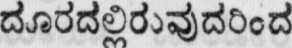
ದೂರದಲ್ಲಿರುವುದರಿಂದ
